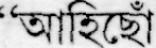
"আহিছোঁ
